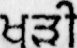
ਖੜੀ
